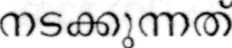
നടക്കുന്നത്
